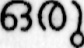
ഒരു
